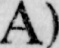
A)
